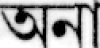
অনা
